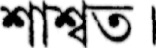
শাশ্বত।
